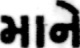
માને
